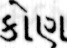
કોણ
